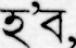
হ'ব,
